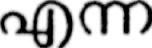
എന്ന
